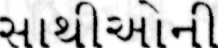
સાથીઓની
